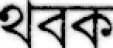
থবক
